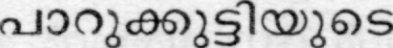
പാറുക്കുട്ടിയുടെ
